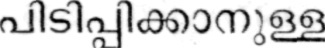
പിടിപ്പിക്കാനുള്ള
